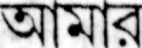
আমার
